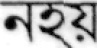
নহয়
